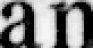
an
